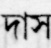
দাস
